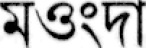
মওংদা
